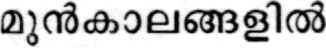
മുന്‍കാലങ്ങളില്‍
